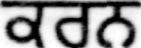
ਕਰਨ
